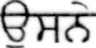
ਉਸਨੇ
